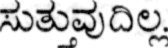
ಸುತ್ತುವುದಿಲ್ಲ.
